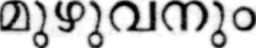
മുഴുവനും
